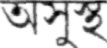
অসুস্থ
